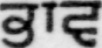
ਭਾਵ
